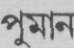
পুমান
